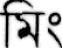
মিং
